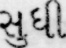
સુધી
